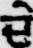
ਦੇ
